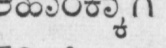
ಆಹಾರಕ್ಕಾಗಿ
